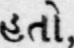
હતો,
